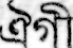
ঐগী
